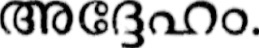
അദ്ദേഹം.
